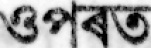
ওপৰত
